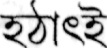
হঠাৎই
